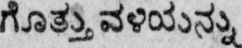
ಗೊತ್ತುವಳಿಯನ್ನು
